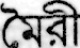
মৈরী
